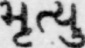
મૃત્યુ
